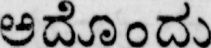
ಅದೊಂದು
